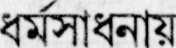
ধর্মসাধনায়
